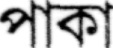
পাকা
